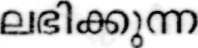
ലഭിക്കുന്ന
